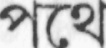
পথে
